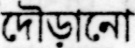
দৌড়ানো
